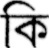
কি
